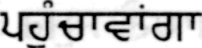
ਪਹੁੰਚਾਵਾਂਗਾ
